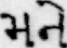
મને
